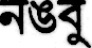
নঙবু
